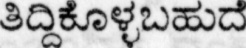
ತಿದ್ದಿಕೊಳ್ಳಬಹುದೆ
